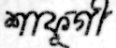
শাফূগী
